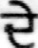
ਦੇ
